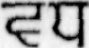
ਵਧ
